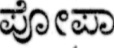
ಪೋಪಾ
